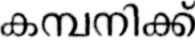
കമ്പനിക്ക്
